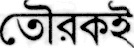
তৌরকই
